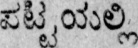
ಪಟ್ಟಿಯಲ್ಲಿ
